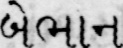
બેભાન
